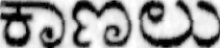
ಕಾಣಲು
